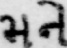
મને
